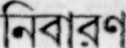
নিবারণ
